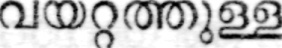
വയറ്റത്തുള്ള
